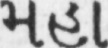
મહા
